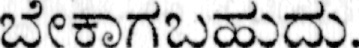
ಬೇಕಾಗಬಹುದು.
